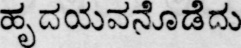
ಹೃದಯವನೊಡೆದು
